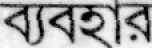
ব্যবহার
